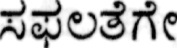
ಸಫಲತೆಗೇ
